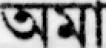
অমা
